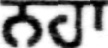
ਨਹਾ
